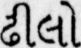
ઢીલો
